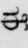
ಈ
